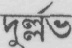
দুৰ্ল্লভ
